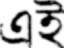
এই
